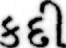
કદી
